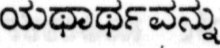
ಯಥಾರ್ಥವನ್ನು
